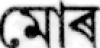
মোৰ
